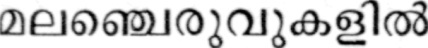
മലഞ്ചെരുവുകളില്‍
